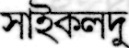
সাইকলদু
